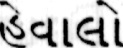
હેવાલો
